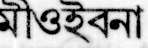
মীওইবনা
